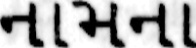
નામના
